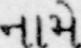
નામે
